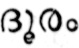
ദൂരം
